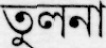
তুলনা
